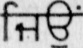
ਜਿਉਂ
